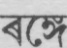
ৰঙ্গে
